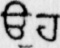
ਉਹ
